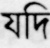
যদি
